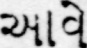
આવે
